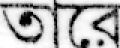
তারে
